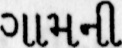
ગામની
